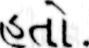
હતો.
